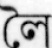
লৈ
